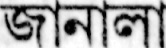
জানালা
